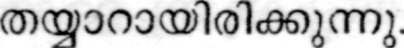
തയ്യാറായിരിക്കുന്നു.
